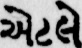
એટલે
